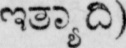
ಇತ್ಯಾದಿ)
